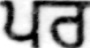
ਪਰ
